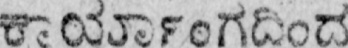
ಕಾರ್ಯಾಂಗದಿಂದ
